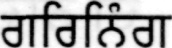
ਗਰਿਨਿੰਗ
